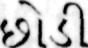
છોડી
